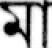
মা
